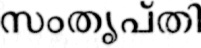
സംതൃപ്തി
